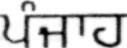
ਪੰਜਾਹ
